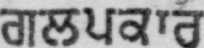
ਗਲਪਕਾਰ
